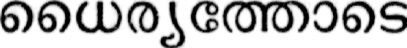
ധൈര്യത്തോടെ
